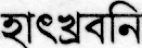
হাৎখ্রবনি
